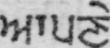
ਆਪਣੇ
